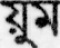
য়ুম
